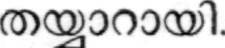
തയ്യാറായി.
